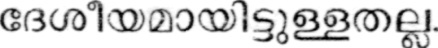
ദേശീയമായിട്ടുള്ളതല്ല.
